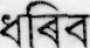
ধৰিব
